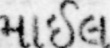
માઈલ
